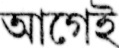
আগেই
